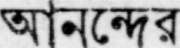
আনন্দের
